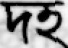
দহ
